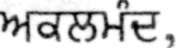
ਅਕਲਮੰਦ,
